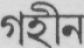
গহীন
